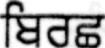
ਬਿਰਛ
